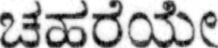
ಚಹರೆಯೇ
